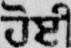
ਹੋਈ
